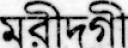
মরীদগী
